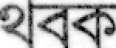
থবক
